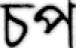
চপ
